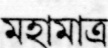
মহামাত্র
